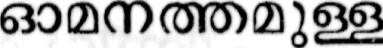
ഓമനത്തമുള്ള
